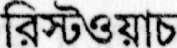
রিস্টওয়াচ
